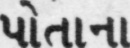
પોતાના
